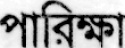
পারিক্ষা
